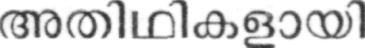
അതിഥികളായി
